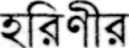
হরিণীর
